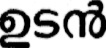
ഉടന്‍
